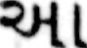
આ
